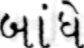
બાંધે
